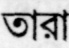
তারা
